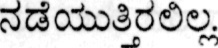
ನಡೆಯುತ್ತಿರಲಿಲ್ಲ.
